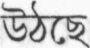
উঠছে
